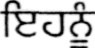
ਇਹਨੂੰ
